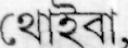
থোইবা,
